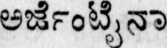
ಅರ್ಜೆಂಟೈನಾ
